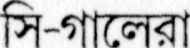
সি-গালেরা
